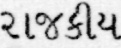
રાજકીય
